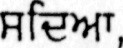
ਸਦਿਆ,
